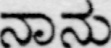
ನಾನು
